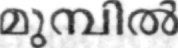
മുമ്പില്‍
